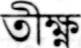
তীক্ষ্ণ
